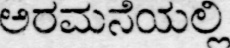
ಅರಮನೆಯಲ್ಲಿ
